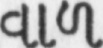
વાળ
